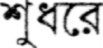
শুধরে
